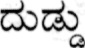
ದುಡ್ಡು
